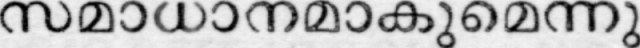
സമാധാനമാകുമെന്നു
